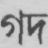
গদ
